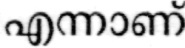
എന്നാണ്
